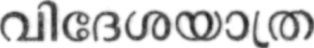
വിദേശയാത്ര
